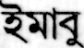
ইমাবু
